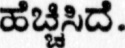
ಹೆಚ್ಚಿಸಿದೆ.
